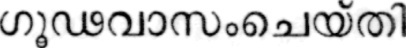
ഗൂഢവാസംചെയ്തി
